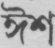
ঈশ
